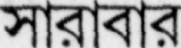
সারাবার
